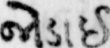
જોડાઈ
